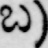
ಬ)
